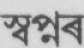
স্বপ্নৰ
